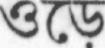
ওড়ে
